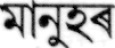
মানুহৰ
